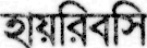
হায়রিবসি
